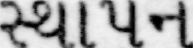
સ્થપાન
